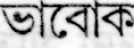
ভাবোক
